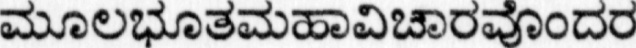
ಮೂಲಭೂತಮಹಾವಿಚಾರವೊಂದರ
